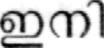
ഇനി
